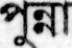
পুন্না
